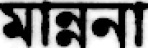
মান্ননা
